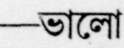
–ভালো
